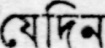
যেদিন
